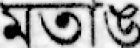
মতাঙ
